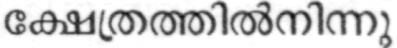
ക്ഷേത്രത്തില്‍നിന്നു
